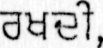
ਰਖਦੀ,
